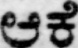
ಆಕೆ
